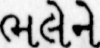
ભલેને
